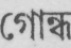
গোন্ধ
